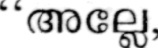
"അല്ലേ,
